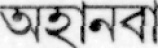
অহানবা
